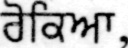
ਰੋਕਿਆ,
